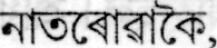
নাতৰোৱাকৈ,
